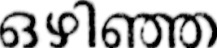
ഒഴിഞ്ഞ
